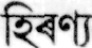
হিৰণ্য
